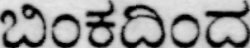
ಬಿಂಕದಿಂದ
